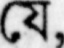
যে,
